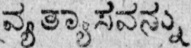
ವ್ಯತ್ಯಾಸವನ್ನು
